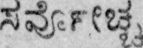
ಸರ್ವೋಚ್ಚ
